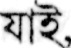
যাই,
